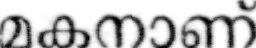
മകനാണ്
